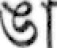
ঙা
